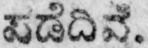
ಪಡೆದಿವೆ.
